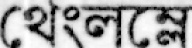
থেংলম্লে
